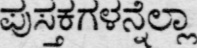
ಪುಸ್ತಕಗಳನ್ನೆಲ್ಲಾ
